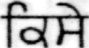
ਕਿਸੇ
